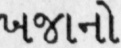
ખજાનો
